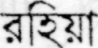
রহিয়া
